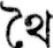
থৈ
